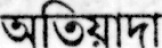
অতিয়াদা
